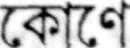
কোণে
